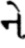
ને
